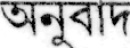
অনুবাদ
